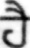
ਹੈ
